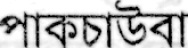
পাকচাউবা
